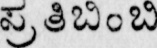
ಪ್ರತಿಬಿಂಬಿ
